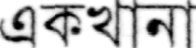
একখানা
